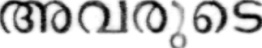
അവരുടെ
